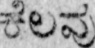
ಕೆಲವು
